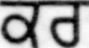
ਕਰ
